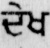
ਦੇਖ
